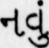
નવું
